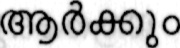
ആര്‍ക്കും
